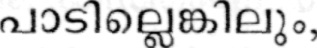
പാടില്ലെങ്കിലും,
